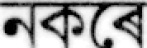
নকৰে
